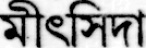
মীৎসিদা
